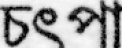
চৎপা
